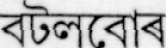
বটলবোৰ
